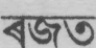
ৰজত
